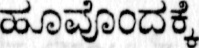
ಹೂವೊಂದಕ್ಕೆ
